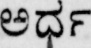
ಅರ್ಧ
